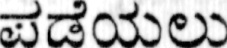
ಪಡೆಯಲು
